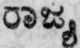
ರಾಜ್ಯ
